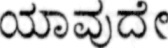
ಯಾವುದೇ
